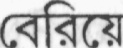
বেরিয়ে
